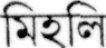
মিহলি
